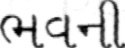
ભવની
